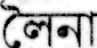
লৈনা
